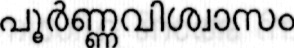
പൂര്‍ണ്ണവിശ്വാസം
